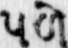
પળે
